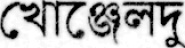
খোঞ্জেলদু
